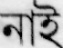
নাই
